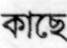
কাছে
